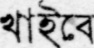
খাইবে
